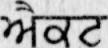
ਐਕਟ
